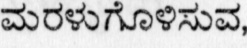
ಮರಳುಗೊಳಿಸುವ,
